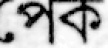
পেক
